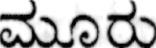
ಮೂರು
